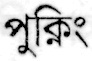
পুক্নিং
